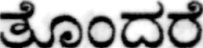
ತೊಂದರೆ
